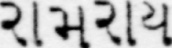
રામરાય
